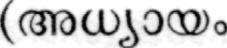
(അധ്യായം
